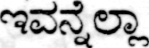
ಇವನ್ನೆಲ್ಲಾ
